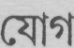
যোগ
